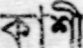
কাশী
